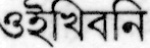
ওইখিবনি
